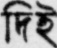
দিই
